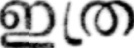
ഇത്ര
